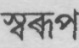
স্বৰূপ
